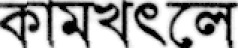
কামখৎলে
